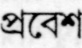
প্রবেশ
